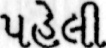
પહેલી
